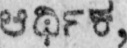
ಆರ್ಥಿಕ,
